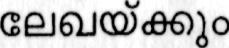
ലേഖയ്ക്കും
